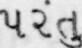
પરંતુ
